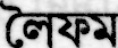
লৈফম
